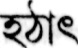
হঠাৎ
